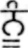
ਨੂੰ
